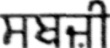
ਸਬਜ਼ੀ
